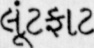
લૂંટફાટ
